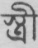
স্ত্ৰী
